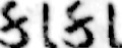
કાકા
